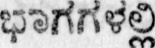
ಭಾಗಗಳಲ್ಲಿ
